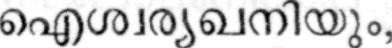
ഐശ്വര്യഖനിയും,
